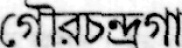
গৌরচন্দ্রগা
